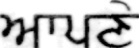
ਆਪਣੇ
